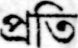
প্রতি
